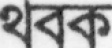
থবক
